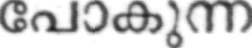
പോകുന്ന
